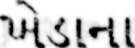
ખેડાના
